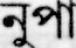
নুপা
